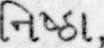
નિષ્ઠા,
